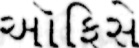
ઑફિસે
